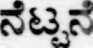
ನೆಟ್ಟನೆ
